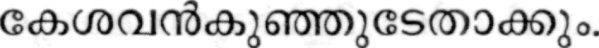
കേശവന്‍കുഞ്ഞുടേതാക്കും.
